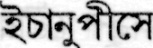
ইচানুপীসে
